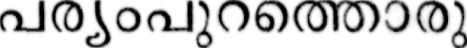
പര്യംപുറത്തൊരു
